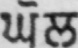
ਘੋਲ
